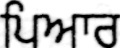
ਪਿਆਰ
